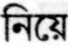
নিয়ে
